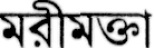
মরীমক্তা
